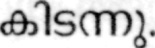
കിടന്നു.
